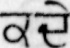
ਕਦੇ
